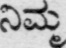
ನಿಮ್ಮ
